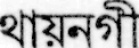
থায়নগী
